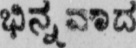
ಭಿನ್ನವಾದ
